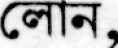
লোন,
